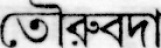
তৌরুবদা
